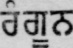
ਰੰਗੂਨ
